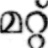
മറ്റ്
